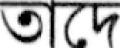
তাদে
